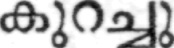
കുറച്ചു
